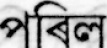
পৰিল
